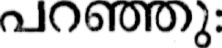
പറഞ്ഞു:
